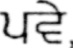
ਪਵੇ,
